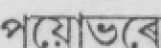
পয়োভৰে
